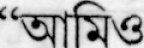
"আমিও
